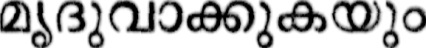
മൃദുവാക്കുകയും
